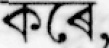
কৰে,
